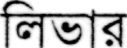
লিভার
